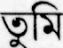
তুমি
